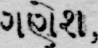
ગણેશ,
